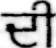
ਦੀ
